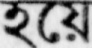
হয়ে
